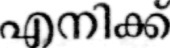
എനിക്ക്
